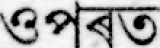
ওপৰত
